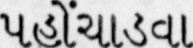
પહોંચાડવા
